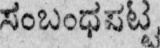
ಸಂಬಂಧಪಟ್ಟ
